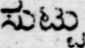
ಸುಟ್ಟು
